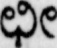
ಛೀ
